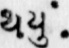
થયું.
